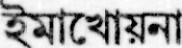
ইমাখোয়না
